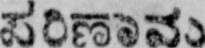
ಪರಿಣಾಮ
